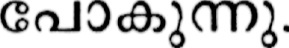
പോകുന്നു.
